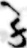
કે
